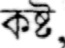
কষ্ট,
